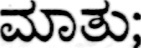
ಮಾತು;
